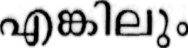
എങ്കിലും
